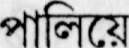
পালিয়ে
